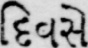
દિવસે
